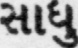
સાધુ
